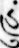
હું
